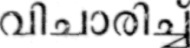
വിചാരിച്ച്
